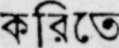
করিতে
